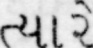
ત્યારે
